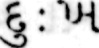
દુઃખ
